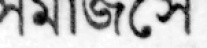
সমাজসে
